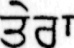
ਤੇਰਾ
